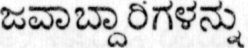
ಜವಾಬ್ದಾರಿಗಳನ್ನು
